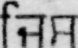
ਜਿਸ
